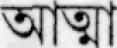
আত্মা
